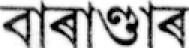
বাৰাণ্ডাৰ
